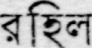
রহিল
